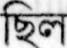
ছিল
